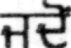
ਜਦੋਂ
